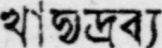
খাদ্যদ্রব্য
